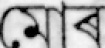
মোৰ
